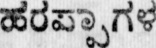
ಹರಪ್ಪಾಗಳ
